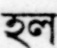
হল
